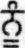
ਨੂੰ
